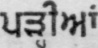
ਪੜ੍ਹੀਆਂ
